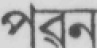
পৱন
